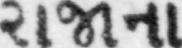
રાજાના
